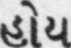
હોય
